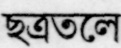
ছত্রতলে
